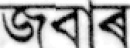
জবাৰ
